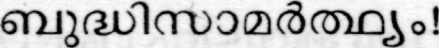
ബുദ്ധിസാമര്‍ത്ഥ്യം!
